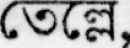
তেল্লে,
